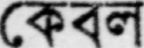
কেবল
